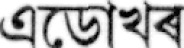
এডোখৰ
